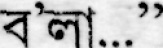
ব'লা..."
